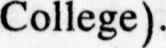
College).
